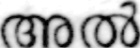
അല്‍
